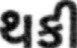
થકી
